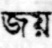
জয়
